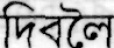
দিবলৈ
